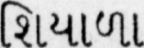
શિયાળા
